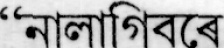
"নালাগিবৰে
